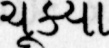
ચૂક્યા
